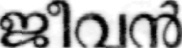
ജീവന്‍
